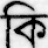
কি
